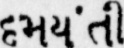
દમયંતી
